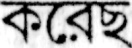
করেছ
